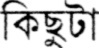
কিছুটা
